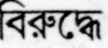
বিরুদ্ধে
